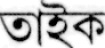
তাইক
